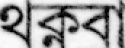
থক্নবা
